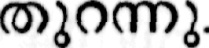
തുറന്നു.
